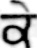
ਕੇ
